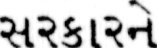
સરકારને
